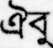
ঐবু
